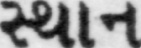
સ્થાન
